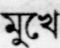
মুখে
